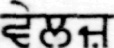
ਵੇਲਜ਼
